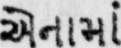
એનામાં
